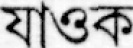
যাওক
